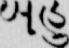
બહુ
